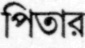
পিতার
